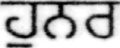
ਹੁਨਰ
